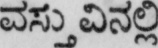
ವಸ್ತುವಿನಲ್ಲಿ
